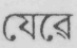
যেৱে
